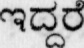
ಇದ್ದರೆ
